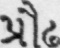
પ્રૌઢ
